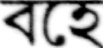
বহে
